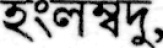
হংলম্বদু,
